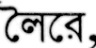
লৈরে,
